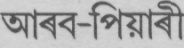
আৰব-পিয়াৰী
